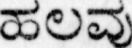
ಹಲವು
